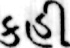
કહી
